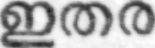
ഇതര
